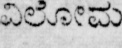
ವಿಲೋಮ
